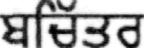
ਬਚਿੱਤਰ
